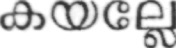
കയല്ലേ
